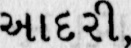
આદરી,
